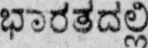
ಭಾರತದಲ್ಲಿ
